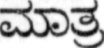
ಮಾತ್ರ
